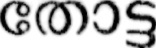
തോട്ട
